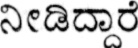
ನೀಡಿದ್ದಾರೆ
